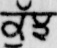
ਕੁੱਝ
